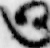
ও
